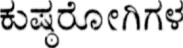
ಕುಷ್ಠರೋಗಿಗಳ
